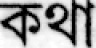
কথা
